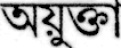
অয়ুক্তা
